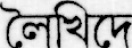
লৈখিদে
